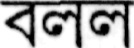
বলল
